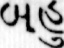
બહુ
